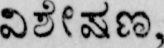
ವಿಶೇಷಣ,
